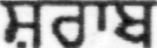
ਸ਼ਰਾਬ
